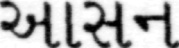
આસન
